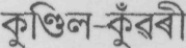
কুণ্ডিল-কুঁৱৰী
